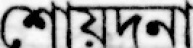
শোয়দনা
